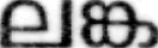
ലങ്ക
